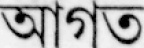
আগত
